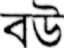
বউ
